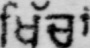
ਖਿੱਚਾਂ
